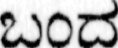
ಬಂದ
